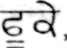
ਫੂਕੇ,
